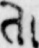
તો
